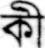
কী
